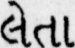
લેતા
